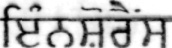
ਇੰਨਸ਼ੋਰੈਂਸ
